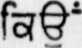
ਕਿਉਂ
